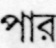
পার
